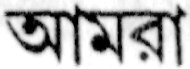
আমরা
